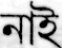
নাই
